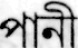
পানী
